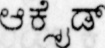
ಆಕ್ಸೈಡ್
